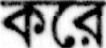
করে
